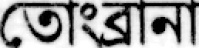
তোংব্রানা
